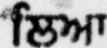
ਲਿਆ
